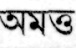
অমত্ত
